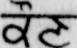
ਕੌਣ
